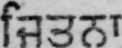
ਜਿਤਨਾ
